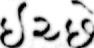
ઇચ્છે
